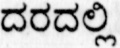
ದರದಲ್ಲಿ
